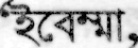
‘ইবেম্মা,
